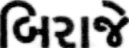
બિરાજે
